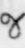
જ
